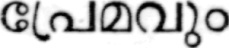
പ്രേമവും
